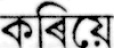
কৰিয়ে
